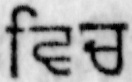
ਵਿਚ
